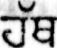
ਹੱਥ
